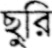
ছুরি
